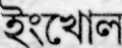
ইংখোল
